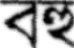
বহু
